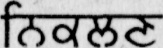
ਨਿਕਲਣ
